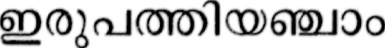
ഇരുപത്തിയഞ്ചാം
